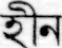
হীন
